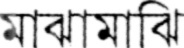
মাঝামাঝি
